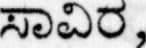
ಸಾವಿರ,
